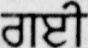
ਗਈ
